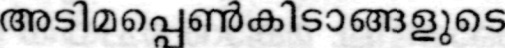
അടിമപ്പെണ്‍കിടാങ്ങളുടെ
